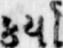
કર્યા
